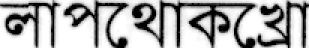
লাপথোকখ্রো
